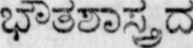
ಭೌತಶಾಸ್ತ್ರದ
